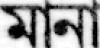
মানা
